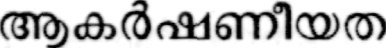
ആകര്‍ഷണീയത
